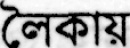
লৈকায়
